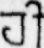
ਹੀ
